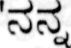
‘ನನ್ನ
